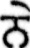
ਨੇ
